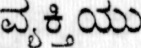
ವ್ಯಕ್ತಿಯು
